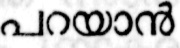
പറയാന്‍
